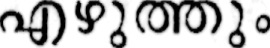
എഴുത്തും
